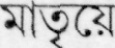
মাতৃয়ে
